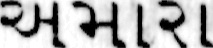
અમારા
